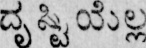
ದೃಷ್ಟಿಯೆಲ್ಲ
